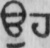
ਉਹ
